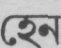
হেন
